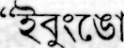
“ইবুংঙো
